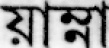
য়াম্না
